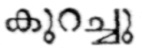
കുറച്ചു
